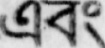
এবং
